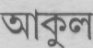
আকুল
